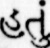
હતું
